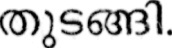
തുടങ്ങി.
